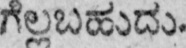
ಗೆಲ್ಲಬಹುದು.
